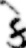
કે
